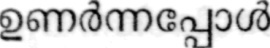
ഉണര്‍ന്നപ്പോള്‍
